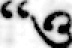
“ও
